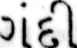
ગંદી
